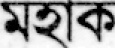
মহাক
